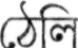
ঠেলি
